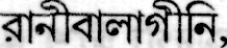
রানীবালাগীনি,
